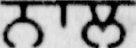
ਨਾਲ
